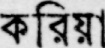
করিয়া
